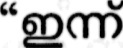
“ഇന്ന്
